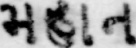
મહાન
